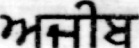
ਅਜੀਬ
